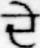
ਦੇ
